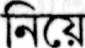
নিয়ে
